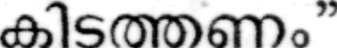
കിടത്തണം”
